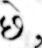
છે,
